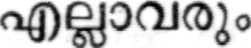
എല്ലാവരും
